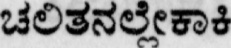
ಚಲಿತನಲ್ಲೇಕಾಕಿ
